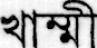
খাম্মী
